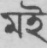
মই
